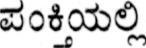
ಪಂಕ್ತಿಯಲ್ಲಿ
